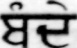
ਬੰਦੇ
